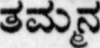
ತಮ್ಮನ
